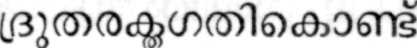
ദ്രുതരക്തഗതികൊണ്ട്
